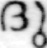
ദു
